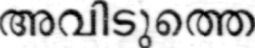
അവിടുത്തെ
